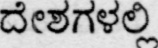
ದೇಶಗಳಲ್ಲಿ
